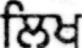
ਲਿਖ
